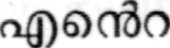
എന്റെ
